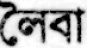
লৈবা
